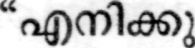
“എനിക്കു
